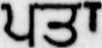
ਪਤਾ
